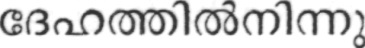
ദേഹത്തില്‍നിന്നു
